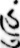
હું
